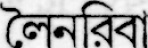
লৈনরিবা
